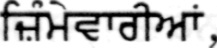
ਜ਼ਿੰਮੇਵਾਰੀਆਂ,
